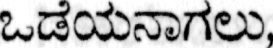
ಒಡೆಯನಾಗಲು,
